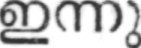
ഇന്നു
